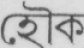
হৌক
